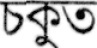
চকুত
